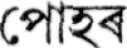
পোহৰ
